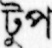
টুপ
